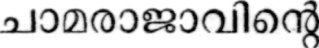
ചാമരാജാവിന്റെ
